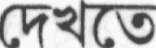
দেখতে
